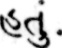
હતું.
